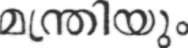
മന്ത്രിയും
